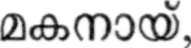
മകനായ്,
